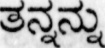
ತನ್ನನ್ನು
